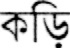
কড়ি
